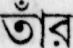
তাঁর
